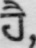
ਹੈ,
